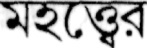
মহত্ত্বের
